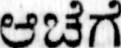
ಆಚೆಗೆ
